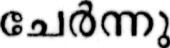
ചേര്‍ന്നു
